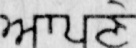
ਆਪਣੇ
